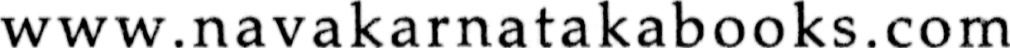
www.navakarnatakabooks.com
